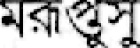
মরূপ্তুসু
